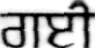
ਗਈ
